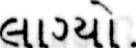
લાગ્યો.
